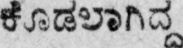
ಕೊಡಲಾಗಿದ್ದ
